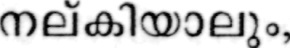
നല്കിയാലും,
